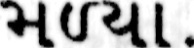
મળ્યા.
